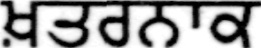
ਖ਼ਤਰਨਾਕ
